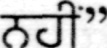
ਨਹੀਂ''
